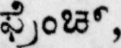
ಫ್ರೆಂಚ್,
